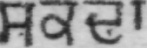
ਸਕਦਾ
